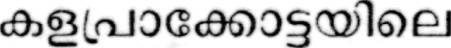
കളപ്രാക്കോട്ടയിലെ
